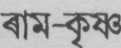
ৰাম-কৃষ্ণ
